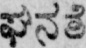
ಘನತೆ
